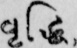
વૃદ્ધિ
